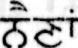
ਨੈਣਾਂ
